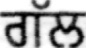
ਗੱਲ
